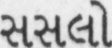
સસલો
